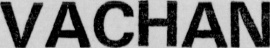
VACHAN
